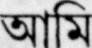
আমি
